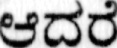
ಆದರೆ
